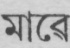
মাৱে
